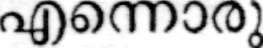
എന്നൊരു
